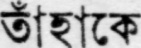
তাঁহাকে
